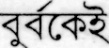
বুর্বকেই
